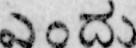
ಎಂದು
